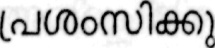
പ്രശംസിക്കു
